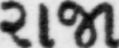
રાજા
